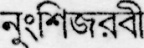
নুংশিজরবী
